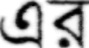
এর
